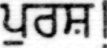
ਪੁਰਸ਼!
